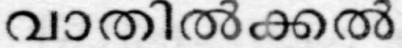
വാതില്‍ക്കല്‍
